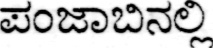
ಪಂಜಾಬಿನಲ್ಲಿ
